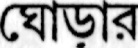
ঘোড়ার
